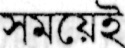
সময়েই
